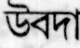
উবদা
